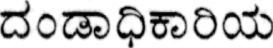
ದಂಡಾಧಿಕಾರಿಯ
